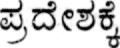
ಪ್ರದೇಶಕ್ಕೆ
